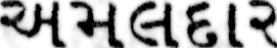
અમલદાર
